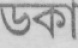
ডকা
